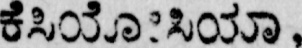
ಕೆಸಿಯೋಸಿಯಾ,
